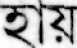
হায়
